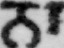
ਨਾ
